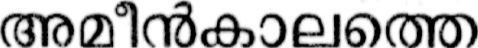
അമീന്‍കാലത്തെ
